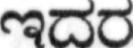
ಇದರ
